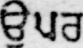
ਉਪਰ
